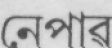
নেপাৱ
